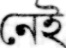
নেই
